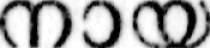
നായ
